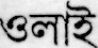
ওলাই
